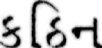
કઠિન
